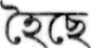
হৈছে
